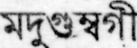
মদুগুম্বগী
